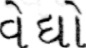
વેદ્યો
